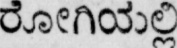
ರೋಗಿಯಲ್ಲಿ
